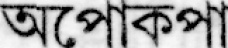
অপোকপা
